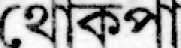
থোকপা
